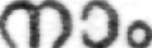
നാം
